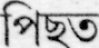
পিছত
